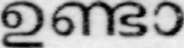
ഉണ്ടാ
